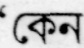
‘কেন
